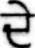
ਦੇ
